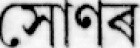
সোণৰ
